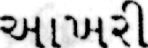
આખરી
